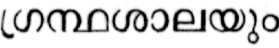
ഗ്രന്ഥശാലയും
